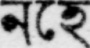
নহে
